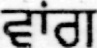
ਵਾਂਗ
